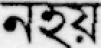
নহয়
